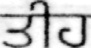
ਤੀਹ
